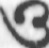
ও
